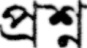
প্রশ্ন
